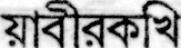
য়াবীরকখি
